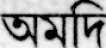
অমদি
